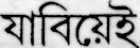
যাবিয়েই
